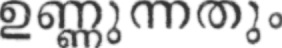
ഉണ്ണുന്നതും
